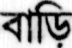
বাড়ি
